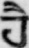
ਹੈ
